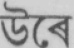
উৰে
